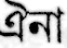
ঐনা
